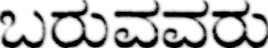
ಬರುವವರು
